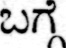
ಬಗ್ಗೆ
